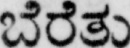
ಬೆರೆತು
